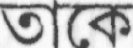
তাকে
